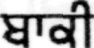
ਬਾਕੀ
